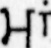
ਮਾਂ
